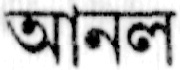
আনল
